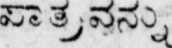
ಪಾತ್ರವನ್ನು
